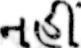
નહીં
